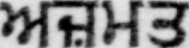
ਅਜ਼ਮਤ
